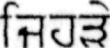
ਜਿਹੜੇ
